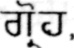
ਗ੍ਰੋਹ,
